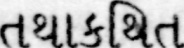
તથાકથિત
